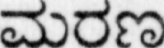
ಮರಣ
